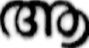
ആ
